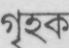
গৃহক
